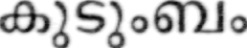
കുടുംബം
